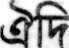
ঐদি
